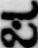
ಪ
